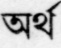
অর্থ
